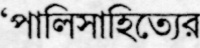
‘পালিসাহিত্যের
